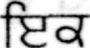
ਇਕ
